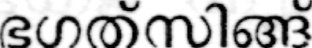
ഭഗത്സിങ്ങ്
